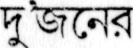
দু'জনের
